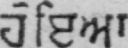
ਹੋਇਆ
